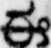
ಈ
